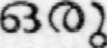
ഒരു
